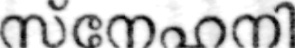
സ്നേഹനി
